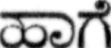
ಹಾಗೆ
